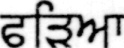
ਫੜਿਆ
